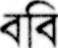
ববি
